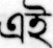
এই
